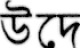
উদে
